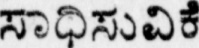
ಸಾಧಿಸುವಿಕೆ
